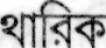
থারিক
